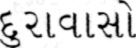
દુરાવાસો
